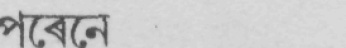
পৰেনে
